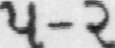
૫-ર
